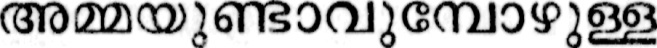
അമ്മയുണ്ടാവുമ്പോഴുള്ള
